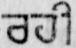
ਰਹੀ
